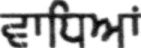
ਵਾਧਿਆਂ
